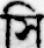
সি
